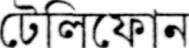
টেলিফোন
